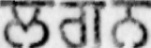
ਲਗਨ
